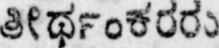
ತೀರ್ಥಂಕರರು
